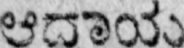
ಆದಾಯ
